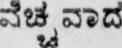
ವೆಚ್ಚವಾದ
